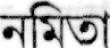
নমিতা
